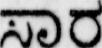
ಸಾರ
